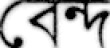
বেন্দ
